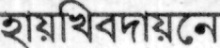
হায়খিবদায়নে
